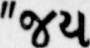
જય
